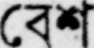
বেশ
